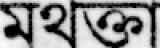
মথক্তা
